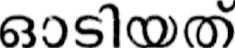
ഓടിയത്
